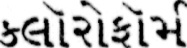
ક્લૉરોફૉર્મ
